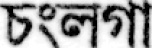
চংলগা
